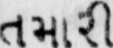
તમારી
